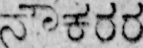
ನೌಕರರ
